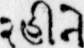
રહીને
